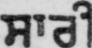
ਸਾਰੀ
